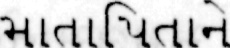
માતાપિતાને
